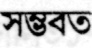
সম্ভবত
